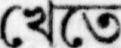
খেতে
